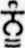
ਨੂੰ
